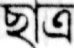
ছাত্র
